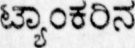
ಟ್ಯಾಂಕರಿನ
